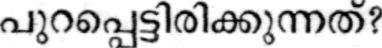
പുറപ്പെട്ടിരിക്കുന്നത്?
